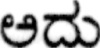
ಅದು
